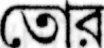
তোর
